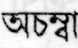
অচম্বা
